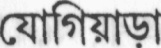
যোগিয়াড়া
